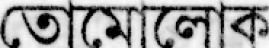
তোমোলোক
